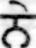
ਨੇ
